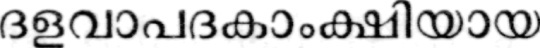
ദളവാപദകാംക്ഷിയായ
